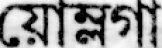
য়োম্লগা
